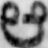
ಆ
